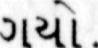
ગયો.
